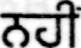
ਨਹੀਂ
